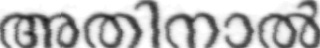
അതിനാല്‍
